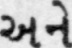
અને
